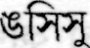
ঙসিসু
